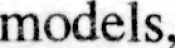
models,
